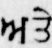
ਅਤੇ
